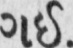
ગઈ.
